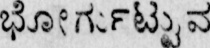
ಭೋರ್ಗುಟ್ಟುವ
